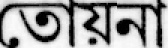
তোয়না
